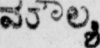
ಮೌಲ್ಯ
